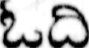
ಓದಿ
